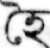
হৈ
